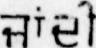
ਜਾਂਦੀ
